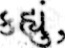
કહ્યું,
